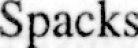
Spacks
